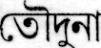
তৌদুনা
